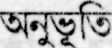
অনুভূতি
